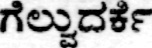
ಗೆಲ್ವುದರ್ಕೆ
